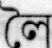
লৈ
